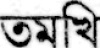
তমখি
